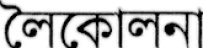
লৈকোলনা
